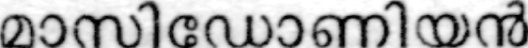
മാസിഡോണിയന്‍
